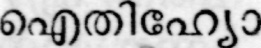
ഐതിഹ്യോ
